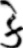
કે
